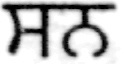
ਸਨ
